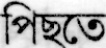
পিছতে
